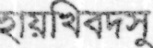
হায়খিবদসু
